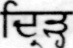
ਦ੍ਰਿੜ੍ਹ
